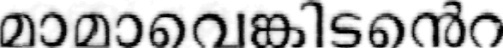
മാമാവെങ്കിടന്റെ
